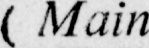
(Main
